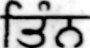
ਤਿੰਨ
